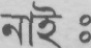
নাইঃ
